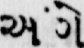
અંગે
